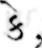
કે,
